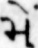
મેં
